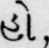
હો,
